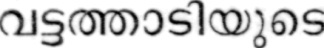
വട്ടത്താടിയുടെ
